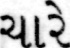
ચારે
